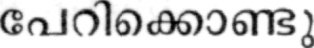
പേറിക്കൊണ്ടു
